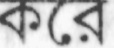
করে
